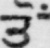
ਤੋਂ
